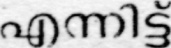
എന്നിട്ട്
